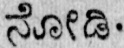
ನೋಡಿ.
